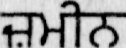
ਜ਼ਮੀਨ
